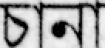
চানা
